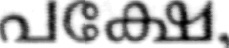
പക്ഷേ,
